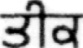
ਤੀਕ
